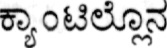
ಕ್ಯಾಂಟಿಲ್ಲೊನ
